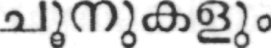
ചൂനുകളും
